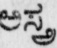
ಅಸ್ತ್ರ
